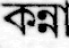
কন্না
